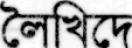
লৈখিদে
